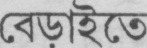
বেড়াইতে
